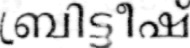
ബ്രിട്ടീഷ്
